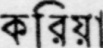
করিয়া
